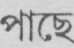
পাছে
